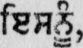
ਇਸਨੂੰ,
